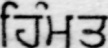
ਹਿੰਮਤ
